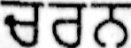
ਚਰਨ
